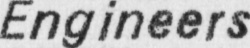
Engineers
